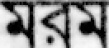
মরম
